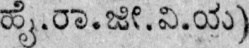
ಹೈ.ರಾ.ಜೀ.ವಿ.ಯ)
